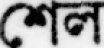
শেল
